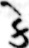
કે
